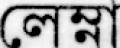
লেম্না
